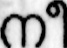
നീ
